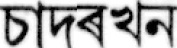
চাদৰখন
